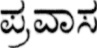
ಪ್ರವಾಸ
